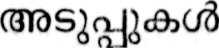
അടുപ്പുകള്‍
